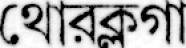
থোরক্লগা
